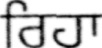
ਰਿਹਾ
